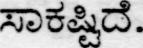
ಸಾಕಷ್ಟಿದೆ.
